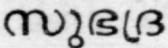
സുഭദ്ര
